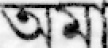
অমা
